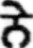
ਨੇ
